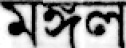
মঙ্গল
